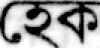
হেক
